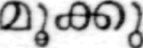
മൂക്കു
